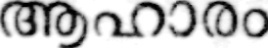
ആഹാരം
